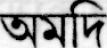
অমদি
